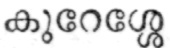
കുറേശ്ശേ
